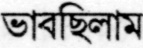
ভাবছিলাম
